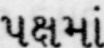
પક્ષમાં
